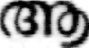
ആ
